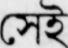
সেই
